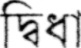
দ্বিধা
